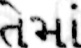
તેમાં
